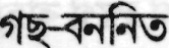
গছ-বননিত
